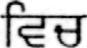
ਵਿਚ
